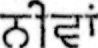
ਨੀਵਾਂ
